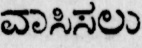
ವಾಸಿಸಲು
